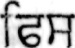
ਫਿਸ
